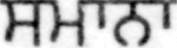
ਸਮਾਨਾ
